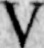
V
